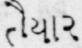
તૈયાર
